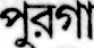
পুরগা
